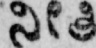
ನೀತಿ
